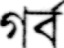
গর্ব
